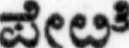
ಪೇೞೆ
